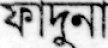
ফাদুনা
